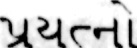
પ્રયત્નો
